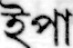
ইপা
